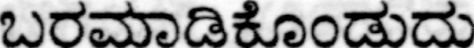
ಬರಮಾಡಿಕೊಂಡುದು
